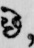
છે,
